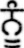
ਨੂੰ
